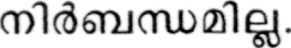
നിര്‍ബന്ധമില്ല.
